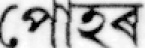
পোহৰ
